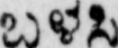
ಬಳಸಿ
